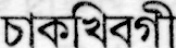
চাকখিবদগী
